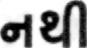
નથી
